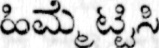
ಹಿಮ್ಮೆಟ್ಟಿಸಿ
